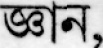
জ্ঞান,
